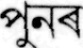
পুনৰ
